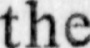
the
